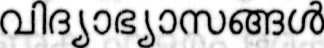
വിദ്യാഭ്യാസങ്ങള്‍
